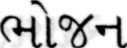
ભોજન
